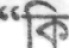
"কি
